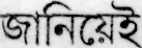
জানিয়েই
